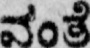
ವಂತೆ
